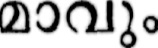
മാവും
